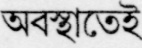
অবস্থাতেই
